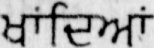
ਖਾਂਦਿਆਂ
